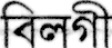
বিলগী
